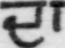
ਦਾ
